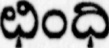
ಛಿ೦ಧಿ
